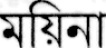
ময়িনা
